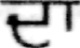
ਦਾ
